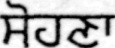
ਸੋਹਣਾ
